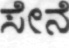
ಸೇನೆ
